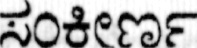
ಸಂಕೀರ್ಣ
